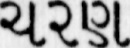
ચરણ
